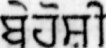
ਬੇਹੋਸ਼ੀ
